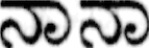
ನಾನಾ
